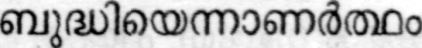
ബുദ്ധിയെന്നാണര്‍ത്ഥം
